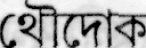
থৌদোক
